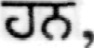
ਹਨ,
